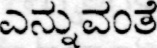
ಎನ್ನುವಂತೆ
